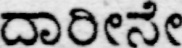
ದಾರೀನೇ
